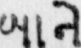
બાને
